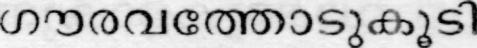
ഗൌരവത്തോടുകൂടി
